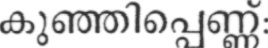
കുഞ്ഞിപ്പെണ്ണ്:
